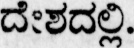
ದೇಶದಲ್ಲಿ.
